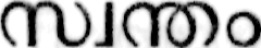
സ്വന്തം
